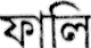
ফালি
